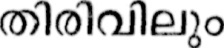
തിരിവിലും
